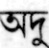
অদু
